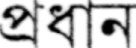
প্রধান
